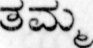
ತಮ್ಮ
